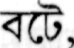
বটে,
